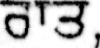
ਰਾਤ,
